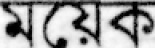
ময়েক
